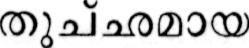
തുച്ഛമായ
